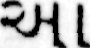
આ
